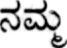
ನಮ್ಮ
